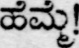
ಹೆಮ್ಮೆ!
